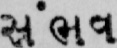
સંભવ
